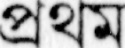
প্রথম
